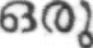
ഒരു
